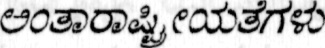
ಅಂತರಾಷ್ಟ್ರೀಯತೆಗಳು
